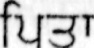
ਪਿਤਾ
